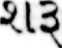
શરૂ
